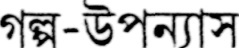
গল্প-উপন্যাস
